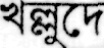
খল্লুদে
